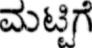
ಮಟ್ಟಿಗೆ
